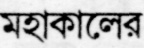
মহাকালের
